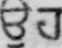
ਉਹ
